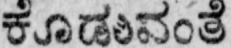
ಕೊಡುವಂತೆ
